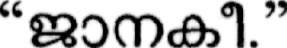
“ജാനകീ.”
